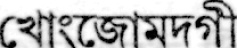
খোংজোমদগী
